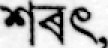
শৰৎ,
